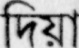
দিয়া
